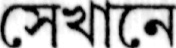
সেখানে
